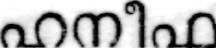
ഹനീഫ
